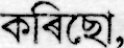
কৰিছো,
